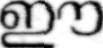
ഈ
